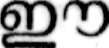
ഈ
